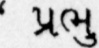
'પ્રભુ
